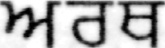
ਅਰਥ
